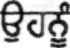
ਉਹਨੂੰ
